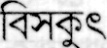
বিসকুৎ
